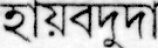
হায়বদুদা
